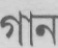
গান
